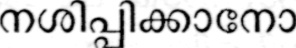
നശിപ്പിക്കാനോ
